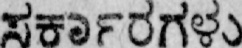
ಸರ್ಕಾರಗಳು
